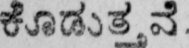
ಕೊಡುತ್ತವೆ.
